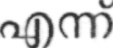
എന്ന്
